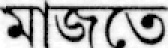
মাজতে
